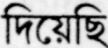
দিয়েছি
